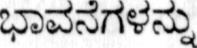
ಭಾವನೆಗಳನ್ನು
